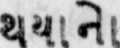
થયાનો
